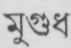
মুগুধ
